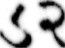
ડર
